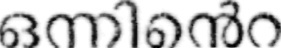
ഒന്നിന്റെ
